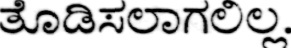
ತೊಡಿಸಲಾಗಲಿಲ್ಲ.
